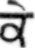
ਕੇ
